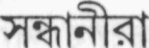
সন্ধানীরা
